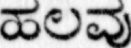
ಹಲವು
